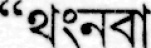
“থংনবা
